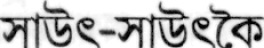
সাউৎ-সাউৎকৈ
